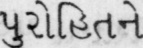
પુરોહિતને
